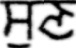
ਸੁਣ
